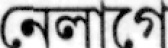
নেলাগে
